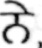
ਨੇ,
